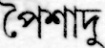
পৈশাদু
